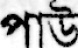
পাউ
